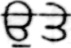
ਉਤੇ
